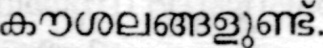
കൌശലങ്ങളുണ്ട്.
